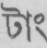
টাং
